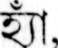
হ্যাঁ,
